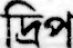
দ্রিপ
